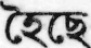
হৈছে
